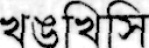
খঙসিসি
